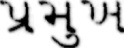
પ્રમુખ
